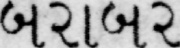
બરાબર
